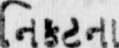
નિકટના
